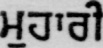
ਮੁਹਾਰੀ
